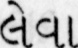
લેવા
